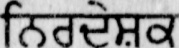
ਨਿਰਦੇਸ਼ਕ
